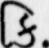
કિ.
